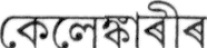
কেলেঙ্কাৰীৰ
